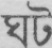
ঘট
